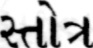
સ્તોત્ર
